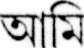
আমি
